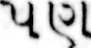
પણ
